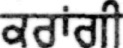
ਕਰਾਂਗੀ
